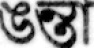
ঙন্তা
